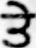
ਤੇ
